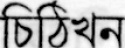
চিঠিখন
